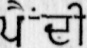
ਪੈਂਦੀ
